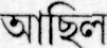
আছিল
